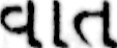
વાત
